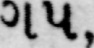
ગપ,
